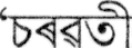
'চৰৱতী
